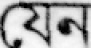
যেন
